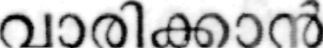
വാരിക്കാന്‍
